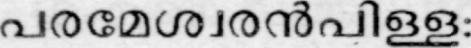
പരമേശ്വരന്‍പിള്ള:
